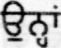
ਉਨ੍ਹਾਂ
